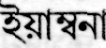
ইয়াম্বনা
